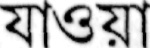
যাওয়া
